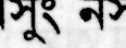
অমসুং
